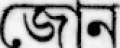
জোন
